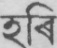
হৰি
